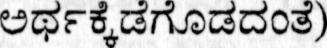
ಅರ್ಥಕ್ಕೆಡೆಗೊಡದಂತೆ)
